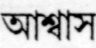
আশ্বাস
